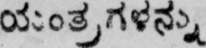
ಯಂತ್ರಗಳನ್ನು
